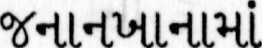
જનાનખાનામાં
